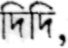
দিদি,
